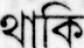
থাকি
